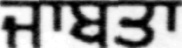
ਜਾਬਤਾ
